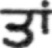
ਤਾਂ
